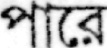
পারে
